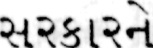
સરકારને
